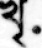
খৃ.
